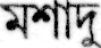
মশাদু
